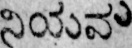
ನಿಯಮ
